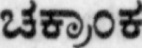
ಚಕ್ರಾಂಕ
